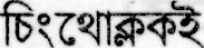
চিংথোক্লকই
